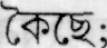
কৈছে;
